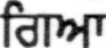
ਗਿਆ
